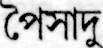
পৈসাদু
